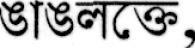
ঙাঙলক্তে,
